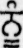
ਨੂੰ
